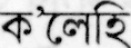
ক'লেহি
